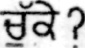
ਚੁੱਕੇ?
